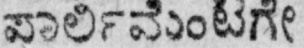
ಪಾರ್ಲಿಮೆಂಟಗೇ
